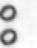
ঃ
